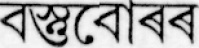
বস্তুবোৰৰ
